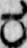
ರ
